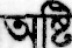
অষ্টি
